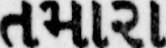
તમારા
